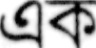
এক
